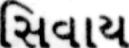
સિવાય
